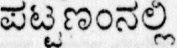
ಪಟ್ಟಣಂನಲ್ಲಿ
